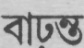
বাঢ়ন্ত
